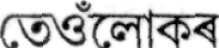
তেওঁলোকৰ
